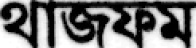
থাজফম
